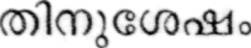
തിനുശേഷം
